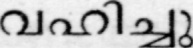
വഹിച്ചു
